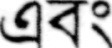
এবং
